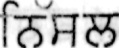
ਨਿੱਸਲ
